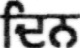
ਦਿਨ
